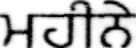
ਮਹੀਨੇ
